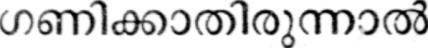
ഗണിക്കാതിരുന്നാല്‍
